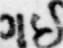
ગઈ
